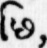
છિ,
